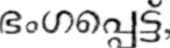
ഭംഗപ്പെട്ട്,
